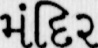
મંદિર
